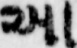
આ
